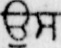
ਉਸ
